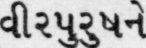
વીરપુરુષને
